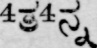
4ತ4ನ್ನ
